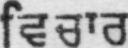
ਵਿਚਾਰ
